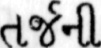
તર્જની
